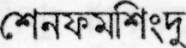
শেনফমশিংদু
